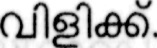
വിളിക്ക്.
